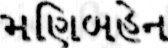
મણિબહેન
